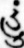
હું
